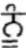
ਨੂੰ
